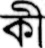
কী
